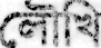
লৌখি
